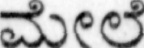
ಮೇಲೆ
